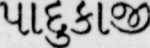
પાદુકાજી
